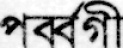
পর্ব্বগী
